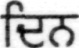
ਦਿਨ
